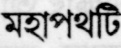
মহাপথটি
